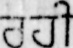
ਰਹੀ
